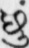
છું
